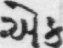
એક
